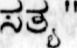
ಸತ್ಯ”
